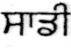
ਸਾਡੀ
